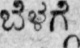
ಬೆಳಗ್ಗೆ
